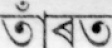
তাঁৰত
